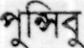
পুন্সিবু
